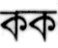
কক
